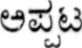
ಅಪ್ಪಟ
